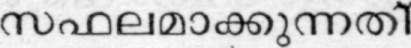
സഫലമാക്കുന്നതി
